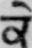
ਕੇ
